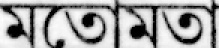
মতোমতা
